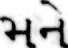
મને
